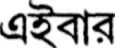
এইবার
